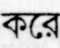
করে
